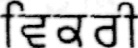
ਵਿਕਰੀ
